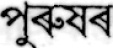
পুৰুষৰ
